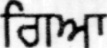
ਗਿਆ
